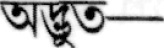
অদ্ভুত-
